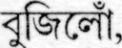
বুজিলোঁ,
